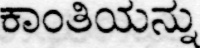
ಕಾಂತಿಯನ್ನು
